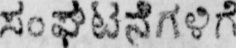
ಸಂಘಟನೆಗಳಿಗೆ
